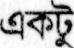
একটু
